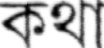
কথা
